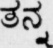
ತನ್ನ
